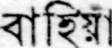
বাহিয়া
